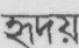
হৃদয়
